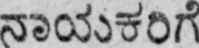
ನಾಯಕರಿಗೆ
